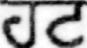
ਹਟ
